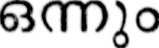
ഒന്നും
